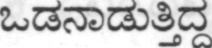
ಒಡನಾಡುತ್ತಿದ್ದ
